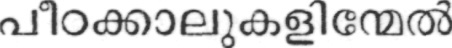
പീഠക്കാലുകളിന്മേല്‍
